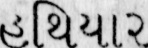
હથિયાર
